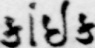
કાંઈક
